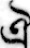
ঐ
